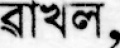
ৱাখল,
